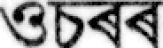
ওচৰৰ
